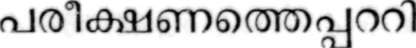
പരീക്ഷണത്തെപ്പററി
